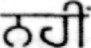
ਨਹੀਂ
